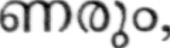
ണരും,
